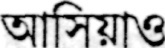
আসিয়াও
